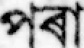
পৰা
